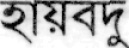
হায়বদু
